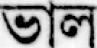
ভাল
